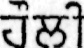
ਹੌਲੀ
